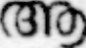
ആ
